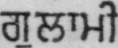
ਗੁਲਾਮੀ
